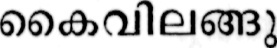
കൈവിലങ്ങു
